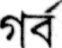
গর্ব
